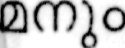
മനും
